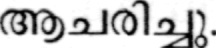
ആചരിച്ചു.
